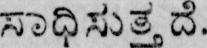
ಸಾಧಿಸುತ್ತದೆ.
